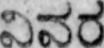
ವಿವರ
